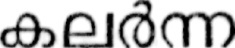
കലര്‍ന്ന
